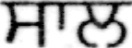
ਸਾਲ
